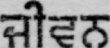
ਜੀਵਨ
